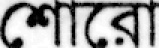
শোরো
